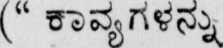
(“ಕಾವ್ಯಗಳನ್ನು
